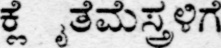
ಕ್ಲೈತೆಮೆಸ್ತ್ರಳಿಗೆ
